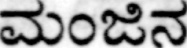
ಮಂಜಿನ
